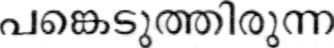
പങ്കെടുത്തിരുന്ന
